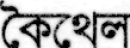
কৈথেল
